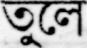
তুলে
